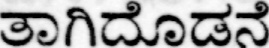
ತಾಗಿದೊಡನೆ
